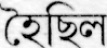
হৈছিল
